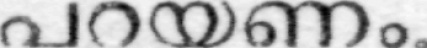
പറയണം.
